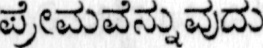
ಪ್ರೇಮವೆನ್ನುವುದು
